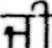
ਜੀ
